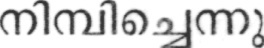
നിമ്പിച്ചെന്നു
